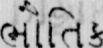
ભૌતિક
